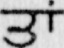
ਤਾਂ
